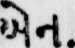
બેન.
